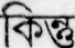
কিন্তু
